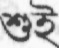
শুই
